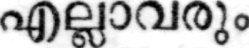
എല്ലാവരും
